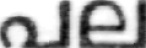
പല
